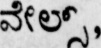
ವೇಲ್ಸ್,
